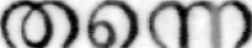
തന്നെ
